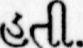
હતી.
